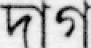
দাগ
